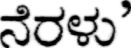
ನೆರಳು'
